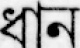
ধান
